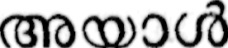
അയാള്‍
